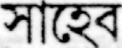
সাহেব
